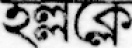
হল্লক্লে
